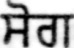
ਸੋਗ
